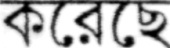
করেছে
